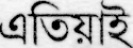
এতিয়াই
